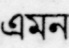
এমন
